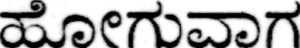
ಹೋಗುವಾಗ
